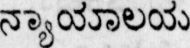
ನ್ಯಾಯಲಯ
